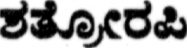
ಶತ್ರೋರಪಿ
